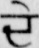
ਦੇ
